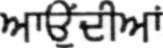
ਆਉਂਦੀਆਂ
